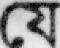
যে
